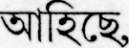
আহিছে,
